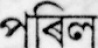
পৰিল
